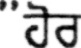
''ਹੋਰ
